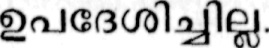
ഉപദേശിച്ചില്ല.
